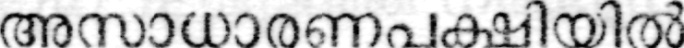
അസാധാരണപക്ഷിയില്‍
